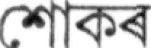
শোকৰ
